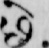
છે.
